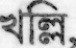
খল্লি,
